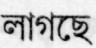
লাগছে
